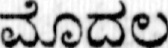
ಮೊದಲ
